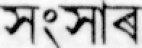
সংসাৰ
